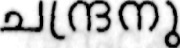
ചന്ദ്രനു
